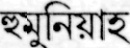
হুমুনিয়াহ
